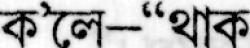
ক'লে-"থাক
